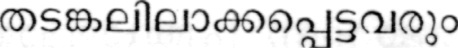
തടങ്കലിലാക്കപ്പെട്ടവരും
